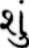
શું
